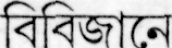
বিবিজানে
